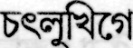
চৎলুখিগে
